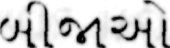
બીજાઓ
